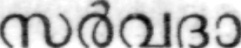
സര്‍വദാ
